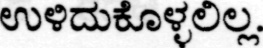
ಉಳಿದುಕೊಳ್ಳಲಿಲ್ಲ.
